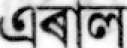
এৰাল
